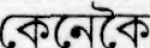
কেনেকৈ
